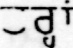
ਤਰ੍ਹਾਂ
